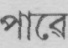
পাৱে
